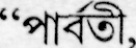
"পার্বতী,
